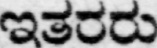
ಇತರರು
